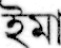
ইমা
